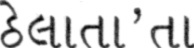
ઠેલાતા'તા
